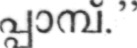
പ്പാമ്പ്."
